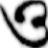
ও
